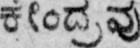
ಕೇಂದ್ರವು
